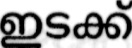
ഇടക്ക്
